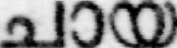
ചായ
